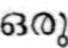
ഒരു
